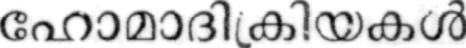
ഹോമാദിക്രിയകള്‍
